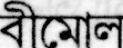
বীমোল
